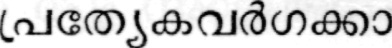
പ്രത്യേകവര്‍ഗക്കാ
